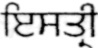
ਇਸਤ੍ਰੀ
